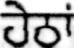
ਹੇਠਾਂ
